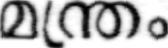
മന്ത്രം
